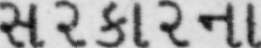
સરકારના
